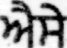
ਐਸੇ
